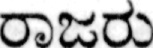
ರಾಜರು
